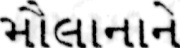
મૌલાનાને
